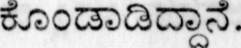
ಕೊಂಡಾಡಿದ್ದಾನೆ.
